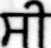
ਸੀ
